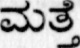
ಮತ್ತೆ
